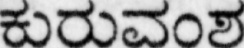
ಕುರುವಂಶ
